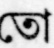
তো
